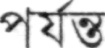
পর্যন্ত
